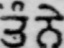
ਤਿੰਨੇ
